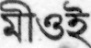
মীওই
